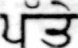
ਪੱਤੇ
